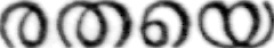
രതയെ
